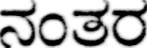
ನಂತರ
